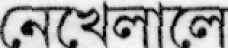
নেখেলালে
